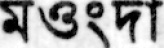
মওংদা
